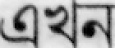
এখন
